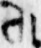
તો
